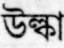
উল্কা
